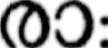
രാ:
